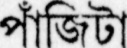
পাঁজিটা
